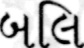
બલિ
